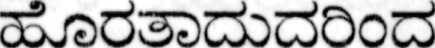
ಹೊರತಾದುದರಿಂದ
